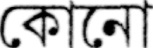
কোনো
